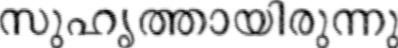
സുഹൃത്തായിരുന്നു
